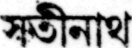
সতীনাথ
